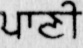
ਪਾਣੀ
